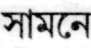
সামনে
